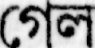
গেল
